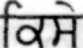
ਕਿਸੇ
